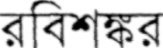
রবিশঙ্কর
